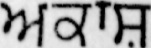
ਅਕਾਸ਼
